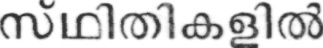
സ്ഥിതികളില്‍
